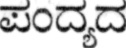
ಪಂದ್ಯದ
